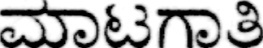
ಮಾಟಗಾತಿ
